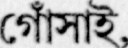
গোঁসাই,
